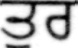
ਤੁਰ
